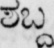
ಶಬ್ದ
